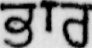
ਭਾਰ
